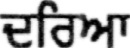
ਦਰਿਆ
